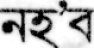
নহ'ব
